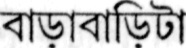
বাড়াবাড়িটা
